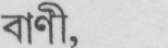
বাণী,
